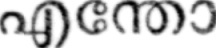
എന്തോ
